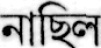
নাছিল
